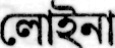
লোইনা
